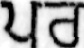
ਪਰ
